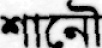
শানৌ
